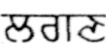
ਲਗਣ
